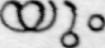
യും
